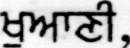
ਖੁਆਣੀ,
